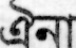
ঐনা
